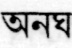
অনঘ
